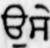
ਉਸੇ
